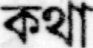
কথা
